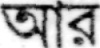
আর
